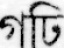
গঢ়ি
